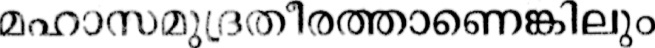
മഹാസമുദ്രതീരത്താണെങ്കിലും
